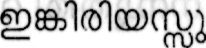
ഇങ്കിരിയസ്സു
